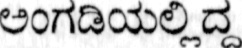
ಅಂಗಡಿಯಲ್ಲಿದ್ದ
